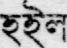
হইল
